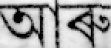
আৰু
